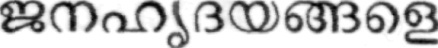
ജനഹൃദയങ്ങളെ
